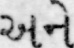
અને
